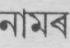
নামৰ
